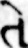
તે
